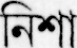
নিশা
